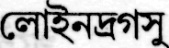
লোইনদ্রগসু
